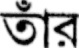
তাঁর
